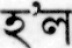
হ'ল
